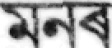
মনৰ
